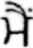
ਮੈਂ
